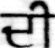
ਦੀ
